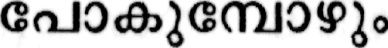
പോകുമ്പോഴും
